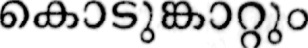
കൊടുങ്കാറ്റും
